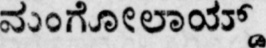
ಮಂಗೋಲಾಯ್ಡ್
